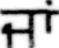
ਜਾਂ
